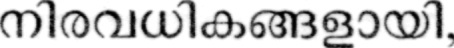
നിരവധികങ്ങളായി,
